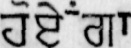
ਹੋਏਂਗਾ
